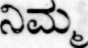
ನಿಮ್ಮ
